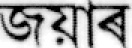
জয়াৰ
